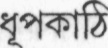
ধূপকাঠি
